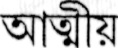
আত্মীয়
